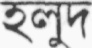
হলুদ
